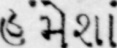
હંમેશાં
